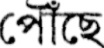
পৌঁছে
